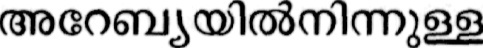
അറേബ്യയില്‍നിന്നുള്ള
